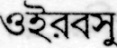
ওইরবসু
